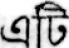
এটি
